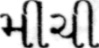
મીચી
